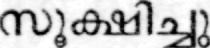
സൂക്ഷിച്ചു
